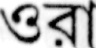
ওরা
